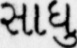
સાધુ
